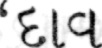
'દાવ
